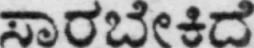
ಸಾರಬೇಕಿದೆ
